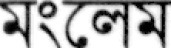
মংলেম
